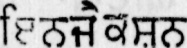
ਇਨਜੈਕਸ਼ਨ
